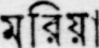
মরিয়া
